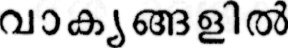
വാക്യങ്ങളില്‍
